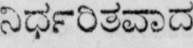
ನಿರ್ಧರಿತವಾದ
